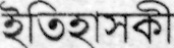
ইতিহাসকী
